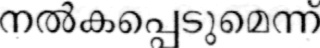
നല്‍കപ്പെടുമെന്ന്
